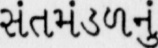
સંતમંડળું
